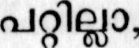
പറ്റില്ലാ,
